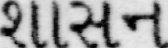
શાસન
